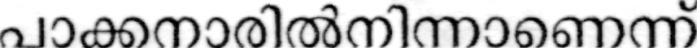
പാക്കനാരില്‍നിന്നാണെന്ന്
